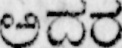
ಅದರ
